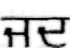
ਜਦ
